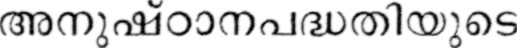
അനുഷ്ഠാനപദ്ധതിയുടെ
